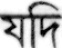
যদি
